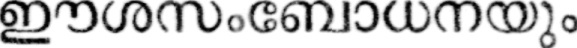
ഈശസംബോധനയും
